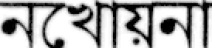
নখোয়না
